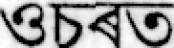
ওচৰত
